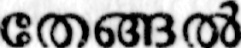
തേങ്ങല്‍
